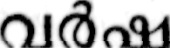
വര്‍ഷ
